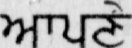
ਆਪਣੇ
